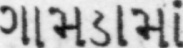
ગામડામાં
